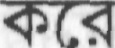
করে
